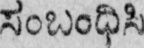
ಸಂಬಂಧಿಸಿ
